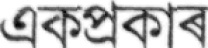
একপ্রকাৰ
